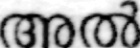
അല്‍
